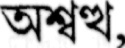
অশ্বত্থ,
